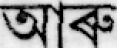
আৰু
